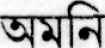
অমনি
